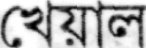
খেয়াল
